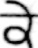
ਕੇ
